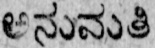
ಅನುಮತಿ
